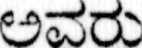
ಅವರು
